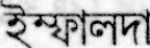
ইম্ফালদা
